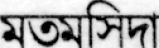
মতমসিদা
